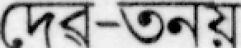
দেৱ-তনয়
